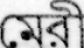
মেরী
